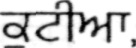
ਕੁਟੀਆ,
